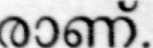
രാണ്.
